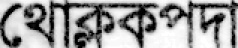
থোক্লকপদা
